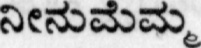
ನೀನುಮೆಮ್ಮ
